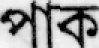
পাক
